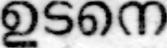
ഉടനെ
